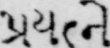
પ્રયત્ને
